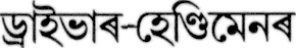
ড্ৰাইভাৰ-হেণ্ডিমেনৰ
